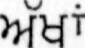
ਅੱਖਾਂ
